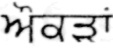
ਔਕੜਾਂ
